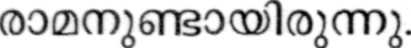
രാമനുണ്ടായിരുന്നു.
